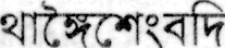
থাঙ্গৈশেংবদি
